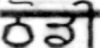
ਠੋਡੀ
